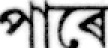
পাৰে
